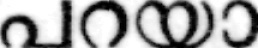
പറയാ
